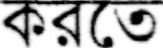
করতে
